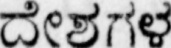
ದೇಶಗಳ
